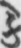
કે
